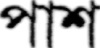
পাশ
